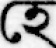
হে
